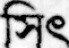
সিৎ
